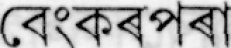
বেংকৰপৰা
